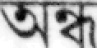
অন্ধ
